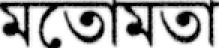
মতোমতা
